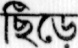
ছিঁড়ে
